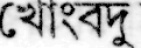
খোংবদু
